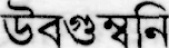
উবগুম্বনি
